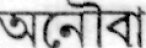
অনৌবা
